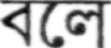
বলে
